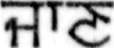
ਜਾਣ
